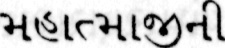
મહાત્માજીની
